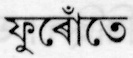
ফুৰোঁতে
